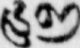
હજી
